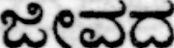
ಜೀವದ
